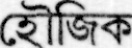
হৌজিক
